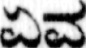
ಏವ
